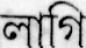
লাগি
